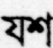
যশ
